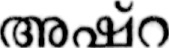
അഷ്റ
